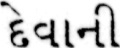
દેવાની
